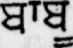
ਬਾਬੂ
